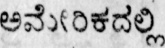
ಅಮೇರಿಕದಲ್ಲಿ
